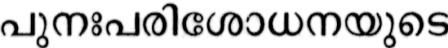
പുനഃപരിശോധനയുടെ
